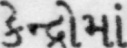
કેન્દ્રોમાં
